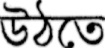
উঠতে
